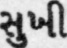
સુખી
